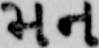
મન
